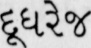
દૂધરેજ
